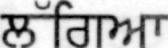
ਲੱਗਿਆ
